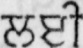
ਲਈ
